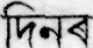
দিনৰ
